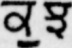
ਕੁਝ
